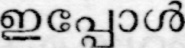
ഇപ്പോള്‍
